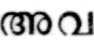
അവ
